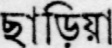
ছাড়িয়া
